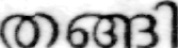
തങ്ങി
